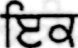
ਇਕ
